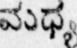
ಮಧ್ಯ
